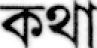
কথা
